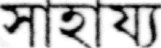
সাহায্য
